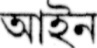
আইন
